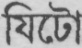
যিটো
